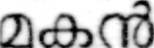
മകന്‍
